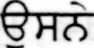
ਉਸਨੇ
